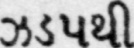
ઝડપથી
